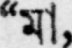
‘‘মা,
